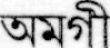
অমগী
